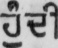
ਹੁੰਦੀ
